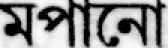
মপানো
